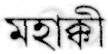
মহাক্কী
